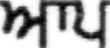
ਆਪ
